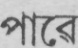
পাৱে
